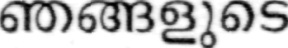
ഞങ്ങളുടെ
